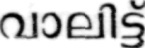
വാലിട്ട്
